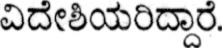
ವಿದೇಶಿಯರಿದ್ದಾರೆ.
